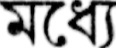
মধ্যে
